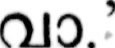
വാ.’
